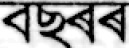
বছৰৰ
